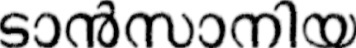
ടാന്‍സാനിയ
